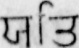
ਯਤਿ
